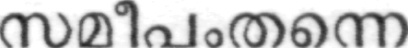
സമീപംതന്നെ
